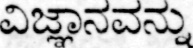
ವಿಜ್ಞಾನವನ್ನು
